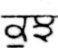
ਕੁਝ
